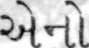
એનો
